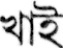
খাই
